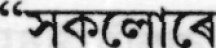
"সকলোৰে
